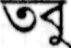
তবু
